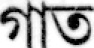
গাত
